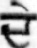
ਦੇ
